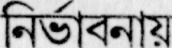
নির্ভাবনায়
